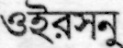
ওইরসনু
